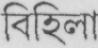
বিহিলা
